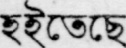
হইতেছে
